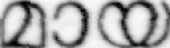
മായ
